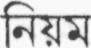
নিয়ম
